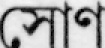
সোণ
